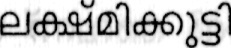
ലക്ഷ്മിക്കുട്ടി
